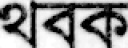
থবক
